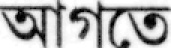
আগতে
